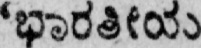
‘ಭಾರತೀಯ
